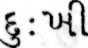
દુઃખી
